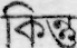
কিন্তু
